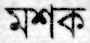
মশক
